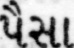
પૈસા
